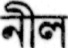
নীল
